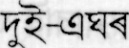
দুই-এঘৰ
